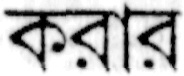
করার
